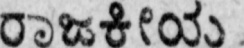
ರಾಜಕೀಯ
